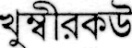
খুন্বীরকউ
